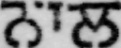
ਨਾਲ
